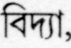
বিদ্যা,
